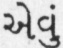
એવું
